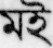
মই
